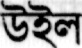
উইল
